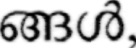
ങ്ങള്‍,
